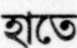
হাতে
